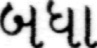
બધા
